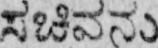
ಸಚಿವನು
